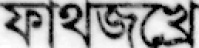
ফাথজখ্রে
